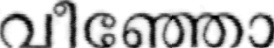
വീഞ്ഞോ
